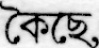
কৈছে,
